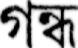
গন্ধ
